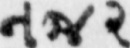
નજર
